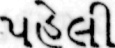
પહેલી
